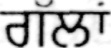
ਗੱਲਾਂ
